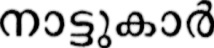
നാട്ടുകാര്‍
